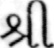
શ્રી
